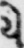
યે
